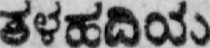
ತಳಹದಿಯ
